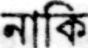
নাকি
